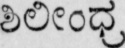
ಶಿಲೀಂಧ್ರ
